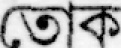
তোক
